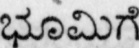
ಭೂಮಿಗೆ
